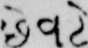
છેવટે
